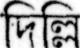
দিল্লি
